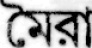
মৈরা
